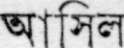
আসিল
